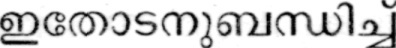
ഇതോടനുബന്ധിച്ച്
